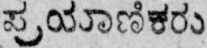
ಪ್ರಯಾಣಿಕರು
